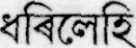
ধৰিলেহি
